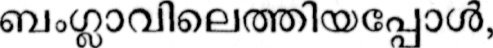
ബംഗ്ലാവിലെത്തിയപ്പോള്‍,
